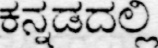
ಕನ್ನಡದಲ್ಲಿ
